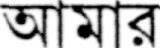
আমার
